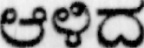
ಆಳಿದ
